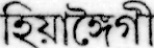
হিয়াঙ্গৈগী
